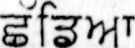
ਛੱਡਿਆ
